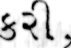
કરી,
